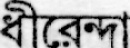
ধীরেন্দা
